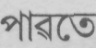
পাৱতে
